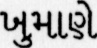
ખુમાણે
